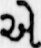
એ
